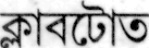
ক্লাবটোত
